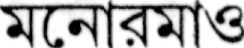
মনোরমাও
